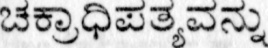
ಚಕ್ರಾಧಿಪತ್ಯವನ್ನು
